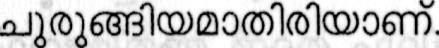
ചുരുങ്ങിയമാതിരിയാണ്.
